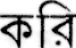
করি
